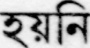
হয়নি
